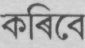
কৰিবে
